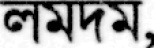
লমদম,
